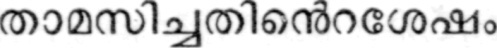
താമസിച്ചതിന്റെശേഷം
